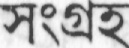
সংগ্রহ
